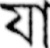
যা
